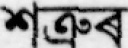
শত্রুৰ
